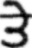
ਤੇ
